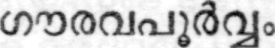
ഗൌരവപൂര്‍വ്വം
